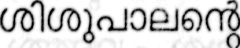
ശിശുപാലന്റെ
